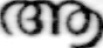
ആ
